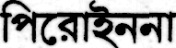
পিরোইননা
